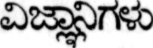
ವಿಜ್ಞಾನಿಗಳು
